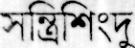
সন্ত্রিশিংদু
